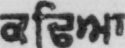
ਕਢਿਆ
